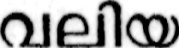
വലിയ
